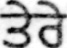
ਤੇਰੇ
